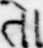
તો
